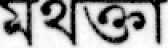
মথক্তা
